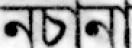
নচানা
